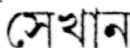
সেখান
